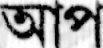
আপ
